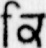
ਕਿ
